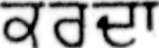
ਕਰਦਾ
